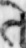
તે
